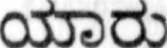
ಯಾರು
